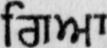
ਗਿਆ
